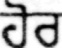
ਹੋਰ
